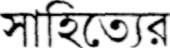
সাহিত্যের
